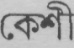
কেশী
